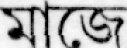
মাজে
